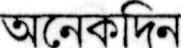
অনেকদিন
